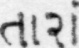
તારાં
